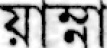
য়াম্না
